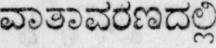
ವಾತಾವರಣದಲ್ಲಿ
